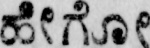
ಹೇಗೋ
